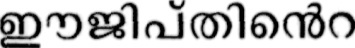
ഈജിപ്തിന്റെ
